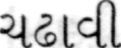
ચઢાવી
